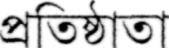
প্রতিষ্ঠাতা
